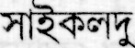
সাইকলদু
